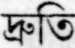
দ্রুতি
